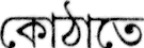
কোঠাতে
